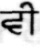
ਵੀ
